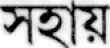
সহায়
